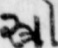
સ્ત્રી
